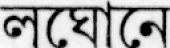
লঘোনে
